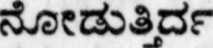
ನೋಡುತ್ತಿರ್ದ
